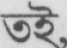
তই,
